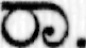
ರಾ.
